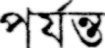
পর্যন্ত
